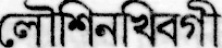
লৌশিনখিবগী
